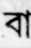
বা
